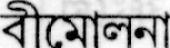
বীমোলনা
